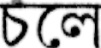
চলে
